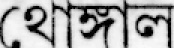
থোঙ্গাল
